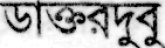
ডাক্তরদুবু
